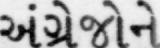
અંગ્રેજોને
